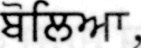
ਬੋਲਿਆ,
